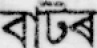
বাটৰ
